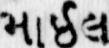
માઈલ
